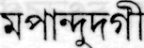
মপান্দুদগী
